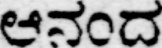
ಆನಂದ
